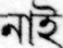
নাই
